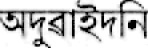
অদুৱাইদনি
